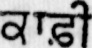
ਕਾਫ਼ੀ
